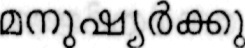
മനുഷ്യര്‍ക്കു
